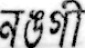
নঙগী
